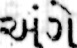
અંગે
